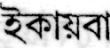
ইকায়বা
